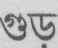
গুড়
